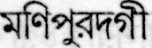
মণিপুরদগী
